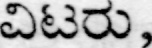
ವಿಟರು,
